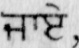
ਜਾਏ,
